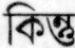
কিন্তু
